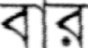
বার
